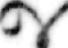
જ
